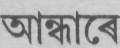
আন্ধাৰে
